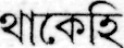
থাকেহি
